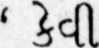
'કેવી
